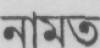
নামত
